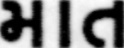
માત
